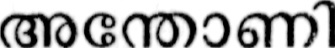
അന്തോണി
